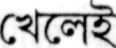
খেলেই
